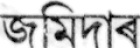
জমিদাৰ
